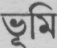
ভূমি
